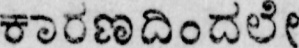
ಕಾರಣದಿಂದಲೇ
